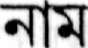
নাম
